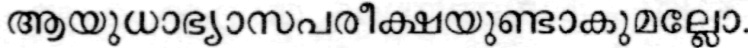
ആയുധാഭ്യാസപരീക്ഷയുണ്ടാകുമല്ലോ.
